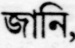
জানি,
